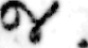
જ.
